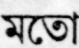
মতো
